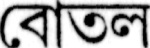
বোতল
